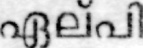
ഏല്പി
